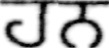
ਹਨ
